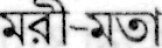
মরী-মতা
